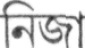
নিজা
